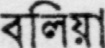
বলিয়া
